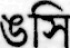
ঙসি
